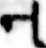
ન
